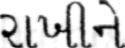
રાખીને
